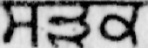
ਸੜਕ
